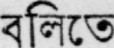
বলিতে
